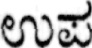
ಉಪ
